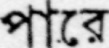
পারে
